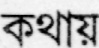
কথায়
